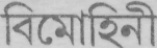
বিমোহিনী
